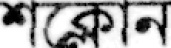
শক্লোন
